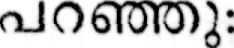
പറഞ്ഞു:
